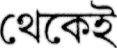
থেকেই
